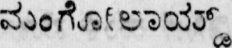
ಮಂಗೋಲಾಯ್ಡ್
